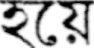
হয়ে
